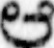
ಆ
